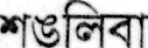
শঙলিবা
